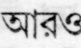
আরও
